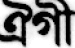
ঐগী
